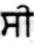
ਸੀ
